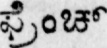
ಫ್ರೆಂಚ್
